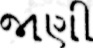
જાણી
